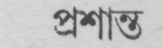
প্ৰশান্ত
